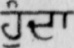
ਹੁੰਦਾ
